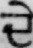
ਦੇ
